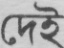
দেই
